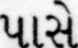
પાસે
